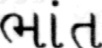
ભાંત
